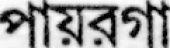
পায়রগা
